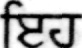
ਇਹ
